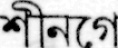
শীনগে
